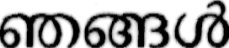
ഞങ്ങള്‍
